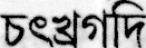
চৎখ্রগদি
